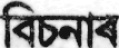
বিচনাৰ
